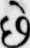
છે
